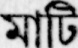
মাটি
